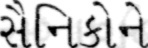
સૈનિકોને
